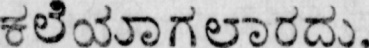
ಕಲೆಯಾಗಲಾರದು.
